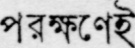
পরক্ষণেই
